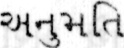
અનુમતિ
